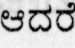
ಆದರೆ
